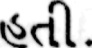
હતી.
